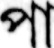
পা
